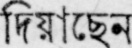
দিয়াছেন
